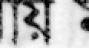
য়
